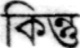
কিন্তু
